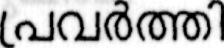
പ്രവര്‍ത്തി
